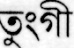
তুংগী
